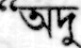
“অদু
